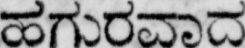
ಹಗುರವಾದ
